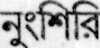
নুংশিরি
